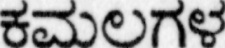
ಕಮಲಗಳ
